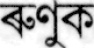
ৰুণুক
